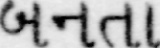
બનતા
